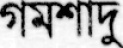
গমশাদু
